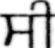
ਸੀ
